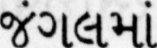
જંગલમાં
